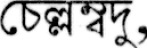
চেল্লম্বদু,
